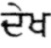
ਦੇਖ
